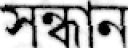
সন্ধান
